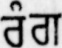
ਰੰਗ
